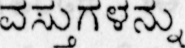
ವಸ್ತುಗಳನ್ನು
